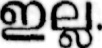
ഇല്ല.
